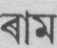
ৰাম
